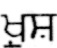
ਖ਼ੁਸ਼
